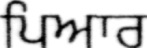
ਪਿਆਰ
